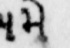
અમે
